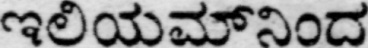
ಇಲಿಯಮ್ನಿಂದ
